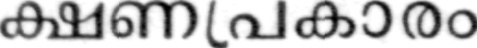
ക്ഷണപ്രകാരം
